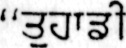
''ਤੁਹਾਡੀ
